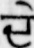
ਦੇ
